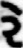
રે
